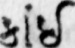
કાંઈ
